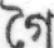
গৈ
